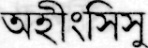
অহীংসিসু
